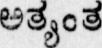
ಅತ್ಯಂತ
